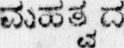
ಮಹತ್ವದ
